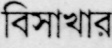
বিসাখার
